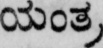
ಯಂತ್ರ
